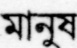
মানুষ
